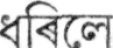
ধৰিলে
